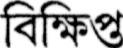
বিক্ষিপ্ত
